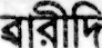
ৱারীদি
